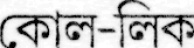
কোল-লিক
